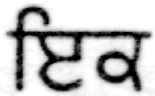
ਇਕ
